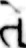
તે
